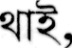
থাই,
